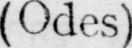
(Odes)
